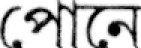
পোনে
